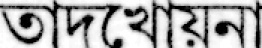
তাদখোয়না
